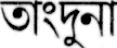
তাংদুনা
